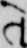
તે
